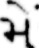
મેં
